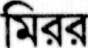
মিরর
